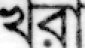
খরা
